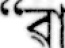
“ৱা
